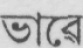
ভাৱে
